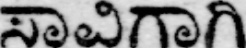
ಸಾವಿಗಾಗಿ
